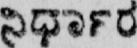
ನಿರ್ಧಾರ
